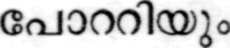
പോററിയും
